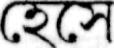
হেসে
